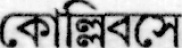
কো্ল্লিবসে
